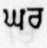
ਘਰ
